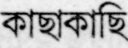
কাছাকাছি
